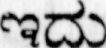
ಇದು
